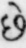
છે
